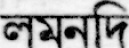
লমনদি
